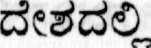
ದೇಶದಲ್ಲಿ
